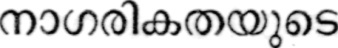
നാഗരികതയുടെ
